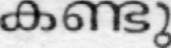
കണ്ടു
